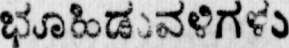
ಭೂಹಿಡುವಳಿಗಳು
